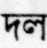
দল
